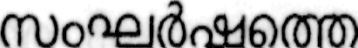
സംഘര്‍ഷത്തെ
